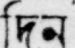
দিন
